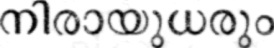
നിരായുധരും
